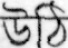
উঠি
